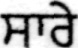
ਸਾਰੇ
